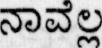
ನಾವೆಲ್ಲ
